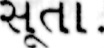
સૂતા.
